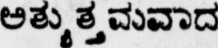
ಅತ್ಯುತ್ತಮವಾದ
